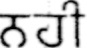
ਨਹੀ
